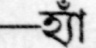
–হ্যাঁ
